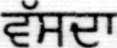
ਵੱਸਦਾ
